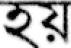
হয়
